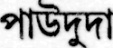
পাউদুদা
